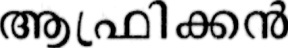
ആഫ്രിക്കന്‍
